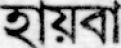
হায়বা
